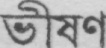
ভীষণ
